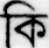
কি
